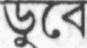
ডুবে
